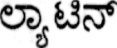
ಲ್ಯಾಟಿನ್
